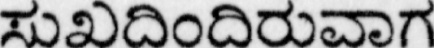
ಸುಖದಿಂದಿರುವಾಗ
